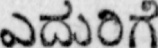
ಎದುರಿಗೆ
